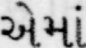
એમાં
